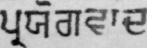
ਪ੍ਰਯੋਗਵਾਦ
